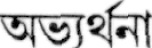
অভ্যর্থনা
